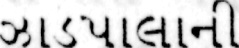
ઝાડપાલાની
